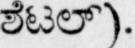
ಶೆಟಲ್).
